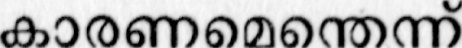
കാരണമെന്തെന്ന്
